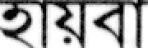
হায়বা
